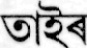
তাইৰ
